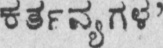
ಕರ್ತವ್ಯಗಳ’
